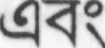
এবং
